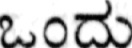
ಒಂದು
